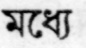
মধ্যে
